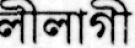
লীলাগী
